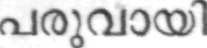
പരുവായി
